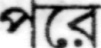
পরে
